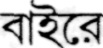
বাইরে
